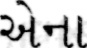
એના
